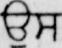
ਉਸ
